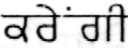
ਕਰੇਂਗੀ
